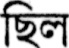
ছিল
